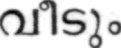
വീടും
